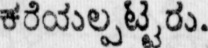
ಕರೆಯಲ್ಪಟ್ಟರು.
